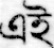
এই
